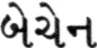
બેચેન
